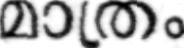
മാത്രം
